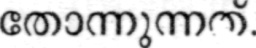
തോന്നുന്നത്.
